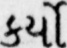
કર્યો
